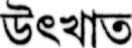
উৎখাত
